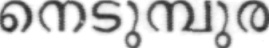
നെടുമ്പുര
